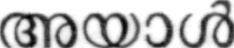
അയാള്‍
